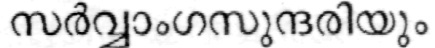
സര്‍വ്വാംഗസുന്ദരിയും
